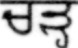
ਚੜ੍ਹ
